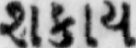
શકાય
